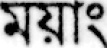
ময়াং
